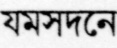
যমসদনে
